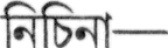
নিচিনা-
